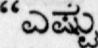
“ಎಷ್ಟು
